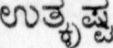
ಉತ್ಕೃಷ್ಟ
